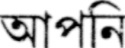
আপনি
